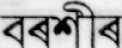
বৰশীৰ
